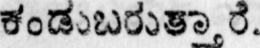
ಕಂಡುಬರುತ್ತಾರೆ.
